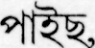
পাইছ,
